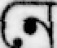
নে
